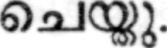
ചെയ്തു.
